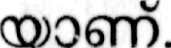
യാണ്.
